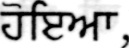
ਹੋਇਆ,
